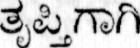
ತೃಪ್ತಿಗಾಗಿ
